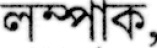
লম্পাক,
